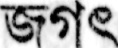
জগৎ
